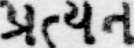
પ્રયત્ન
